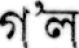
গ'ল
